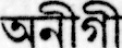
অনীগী
